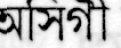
অসিগী
